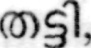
തട്ടി,
